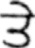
ਤੇ
